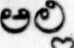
ಅಲ್ಲಿ
